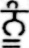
ਨੂੰ
